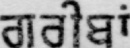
ਗਰੀਬਾਂ
